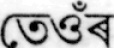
তেওঁৰ
